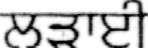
ਲੜਾਈ
